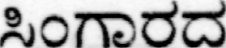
ಸಿಂಗಾರದ
